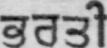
ਭਰਤੀ
